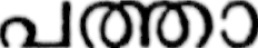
പത്താ
